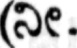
(ನೀ.
